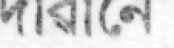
দাৱানে
